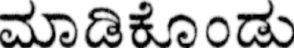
ಮಾಡಿಕೊಂಡು
